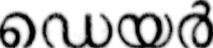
ഡെയര്‍
